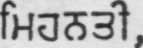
ਮਿਹਨਤੀ,
